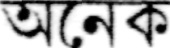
অনেক
